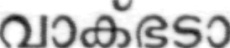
വാക്ഭടാ
